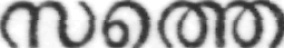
സത്തെ
